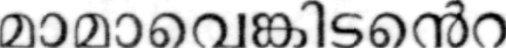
മാമാവെങ്കിടന്റെ
